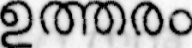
ഉത്തരം
